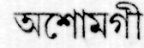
অশোমগী
